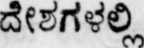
ದೇಶಗಳಲ್ಲಿ
